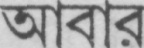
আবার
